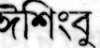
ঈশিংবু
